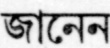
জানেন
